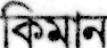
কিমান
